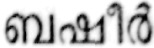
ബഷീര്‍
